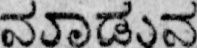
ಮಾಡುವ
